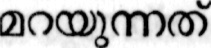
മറയുന്നത്
